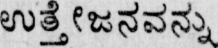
ಉತ್ತೇಜನವನ್ನು
